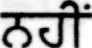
ਨਹੀਂ
